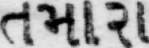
તમારા
